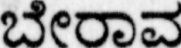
ಬೇರಾವ
